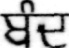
ਬੰਦ
